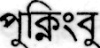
পুক্নিংবু
